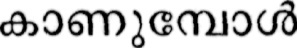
കാണുമ്പോള്‍
